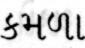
કમળા
